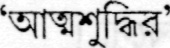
‘আত্মশুদ্ধির’
